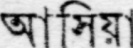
আসিয়া
